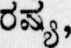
ರಷ್ಯ,
